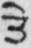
ਤੇ
